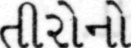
તીરોનો
